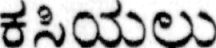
ಕಸಿಯಲು
